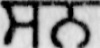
ਸਨ
